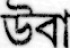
উবা
